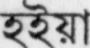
হইয়া
